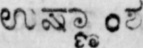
ಉಷ್ಣಾಂಶ
